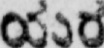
ಯರ
